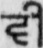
ਵੀ
